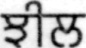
ਝੀਲ
